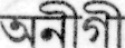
অনীগী
